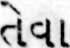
તેવા
